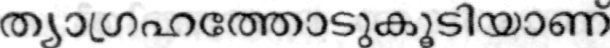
ത്യാഗ്രഹത്തോടുകൂടിയാണ്
